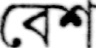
বেশ
